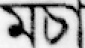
মচা
